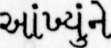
આંખ્યુંને
